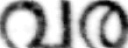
വര
